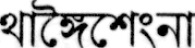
থাঙ্গৈশেংনা
